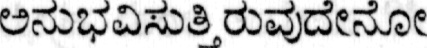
ಅನುಭವಿಸುತ್ತಿರುವುದೇನೋ
